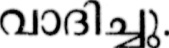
വാദിച്ചു.
